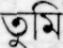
তুমি
